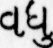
વધુ
